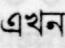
এখন
